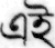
এই
